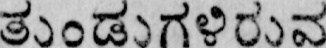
ತುಂಡುಗಳಿರುವ
